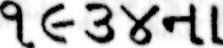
૧૯૩૪ના
